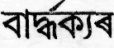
বার্দ্ধক্যৰ
